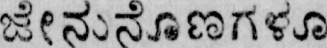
ಜೇನುನೊಣಗಳೂ
